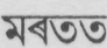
মৰতত
